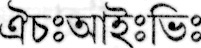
ঐচঃআইঃভিঃ
